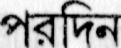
পরদিন
